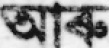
আৰু
